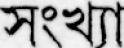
সংখ্যা
